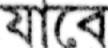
যাবে
